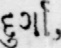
દુર્ગા,
